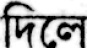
দিলে
